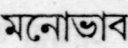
মনোভাব
